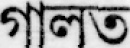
গালত
